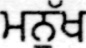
ਮਨੁੱਖ
